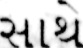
સાથે
